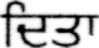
ਦਿਤਾ
